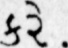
કરે.
